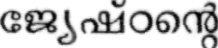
ജ്യേഷ്ഠന്റെ
